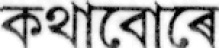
কথাবোৰে
